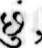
છું,
